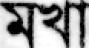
মখা
